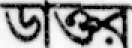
ডাক্তর
